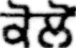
ਕੋਲੋਂ
